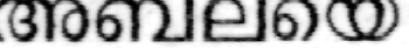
അബലയെ
